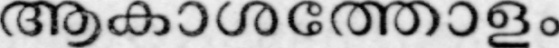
ആകാശത്തോളം
